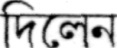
দিলেন
